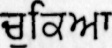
ਚੁਕਿਆ
